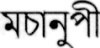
মচানুপী
